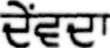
ਦੇਂਵਦਾ
